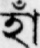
হাঁ
